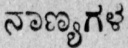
ನಾಣ್ಯಗಳ
